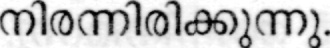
നിരന്നിരിക്കുന്നു.
